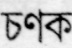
চণক
